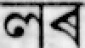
লৰ
